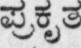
ಪ್ರಕೃತ
